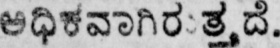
ಅಧಿಕವಾಗಿರುತ್ತದೆ.
